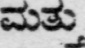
ಮತ್ತು
